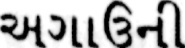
અગાઉની
